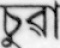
চুৱা
